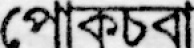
পোকচবা
